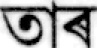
তাৰ
